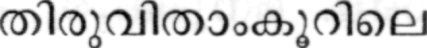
തിരുവിതാംകൂറിലെ
